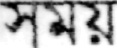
সময়
